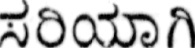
ಸರಿಯಾಗಿ
